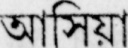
আসিয়া
